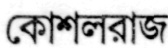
কোশলরাজ
